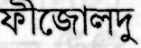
ফীজোলদু
